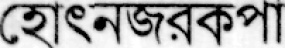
হোৎনজরকপা
